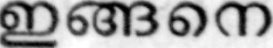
ഇങ്ങനെ
